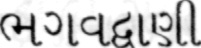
ભગવદ્વાણી
